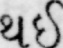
થઈ
